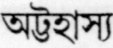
অট্টহাস্য
